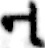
ન
